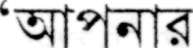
‘আপনার
